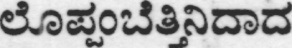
ಲೊಪ್ಪಂಬೆತ್ತಿನಿದಾದ
